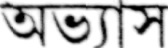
অভ্যাস
